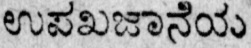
ಉಪಖಜಾನೆಯ
